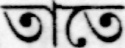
তাতে
